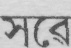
সৱে
